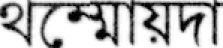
থম্মোয়দা
